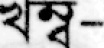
খম্বা-
